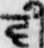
ਵੀ
